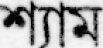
শ্যাম
